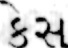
કેસ
